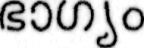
ഭാഗ്യം
